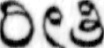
ರೀತಿ
